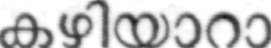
കഴിയാറാ
